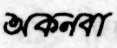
অকনবা
